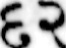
દર
